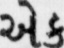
એક
